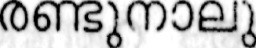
രണ്ടുനാലു
